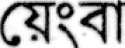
য়েংবা
